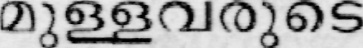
മുള്ളവരുടെ
